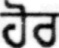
ਹੋਰ
